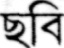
ছবি
